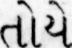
તોયે
